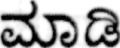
ಮಾಡಿ
